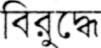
বিরুদ্ধে
